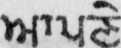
ਆਪਣੇ
